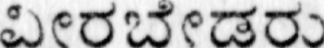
ವೀರಬೇಡರು
